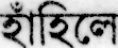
হাঁহিলে
